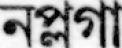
নপ্লগা
